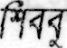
শিববু
